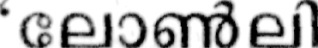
‘ലോണ്‍ലി
